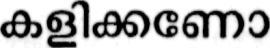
കളിക്കണോ
